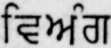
ਵਿਅੰਗ
